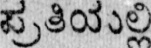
ಪ್ರತಿಯಲ್ಲಿ
